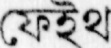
ফেইথ
